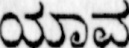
ಯಾವ
